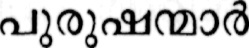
പുരുഷന്മാര്‍
